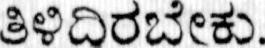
ತಿಳಿದಿರಬೇಕು.
